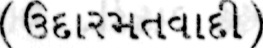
(ઉદારમતવાદી)
